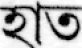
হাত
